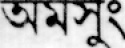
অমসুং
